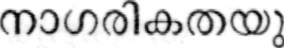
നാഗരികതയു
